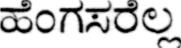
ಹೆಂಗಸರೆಲ್ಲ
